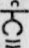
ਨੂੰ
